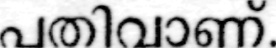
പതിവാണ്.
